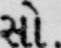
સો.
